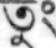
তুং
